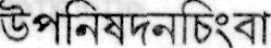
উপনিষদনচিংবা
